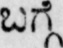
ಬಗ್ಗೆ
